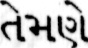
તેમણે
